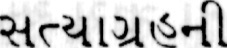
સત્યાગ્રહની
